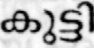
കുട്ടി
